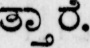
ತ್ತಾರೆ.
